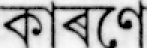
কাৰণে
